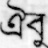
ঐবু
